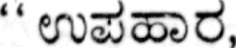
"ಉಪಹಾರ,
